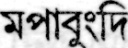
মপাবুংদি
